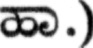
ಹಾ.)
